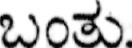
ಬಂತು.
